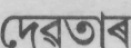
দেৱতাৰ
